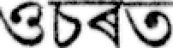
ওচৰত
